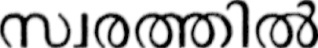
സ്വരത്തില്‍
